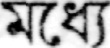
মধ্যে
